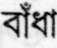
বাঁধা
